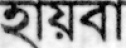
হায়বা
